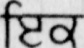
ਇਕ
